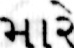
મારે
